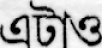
এটাও
